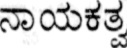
ನಾಯಕತ್ವ
